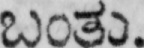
ಬಂತು.
